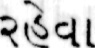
રહેવા
